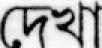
দেখা
